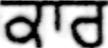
ਕਾਰ
